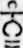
ਨੂੰ
